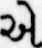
એ
